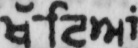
ਖੱਟਿਆਂ
